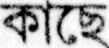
কাছে
